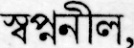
স্বপ্ননীল,
